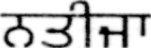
ਨਤੀਜਾ
